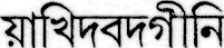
য়াখিদবদগীনি
